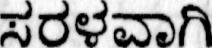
ಸರಳವಾಗಿ
